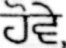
ਹੋਵੇ,
